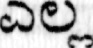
ಎಲ್ಲ
